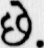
છે.
